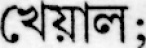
খেয়াল;
